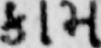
કામ
